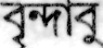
বৃন্দাবু
